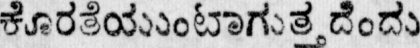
ಕೊರತೆಯುಂಟಾಗುತ್ತದೆಂದು
